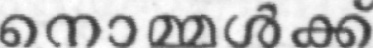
നൊമ്മള്‍ക്ക്
